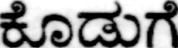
ಕೊಡುಗೆ
